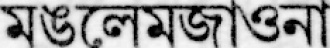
মঙলেমজাওনা
